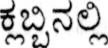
ಕ್ಲಬ್ಬಿನಲ್ಲಿ
